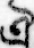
ঐ
